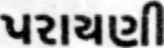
પરાયણી
